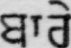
ਬਾਰੇ
